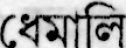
ধেমালি
